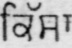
ਕਿੱਸਾ
